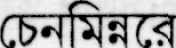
চেনমিন্নরে
